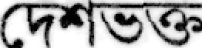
দেশভক্ত
